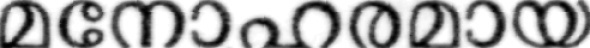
മനോഹരമായ
